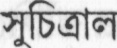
সুচিত্রাল
